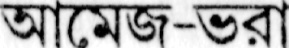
আমেজ-ভরা
